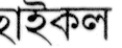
ছাইকল
